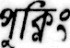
পুক্নিং
